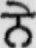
ਨੇ
